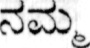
ನಮ್ಮ
